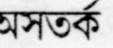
অসতর্ক
